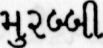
મુરબ્બી
